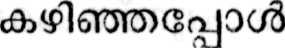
കഴിഞ്ഞപ്പോള്‍
